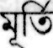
মূর্তি
